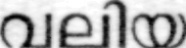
വലിയ
